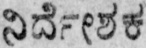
ನಿರ್ದೇಶಕ
